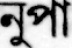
নুপা
